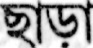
ছাড়া
